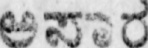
ಅಪಾರ
